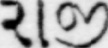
રાજી
